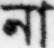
না
